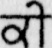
ਕੀ
